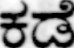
ಕಡೆ
